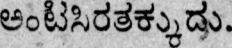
ಅಂಟಿಸಿರತಕ್ಕುದು.
